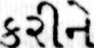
કરીને
